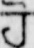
ਹੋ
